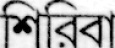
শিরিবা
